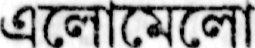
এলোমেলো
